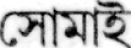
সোমাই
